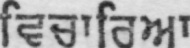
ਵਿਚਾਰਿਆ
